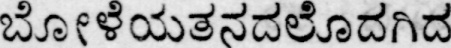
ಬೋಳೆಯತನದಲೊದಗಿದ
